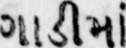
ગાડીમાં
